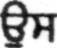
ਉਸ
